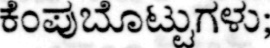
ಕೆಂಪುಬೊಟ್ಟುಗಳು;
